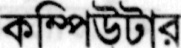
কম্পিউটার
